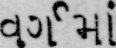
વર્ગમાં
